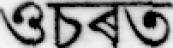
ওচৰত
